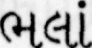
ભલાં
